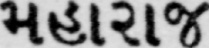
મહારાજ
